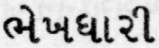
ભેખધારી
